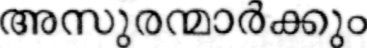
അസുരന്മാര്‍ക്കും
